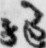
કહે
